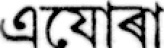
এযোৰা
